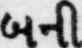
બની
